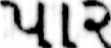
પાર
